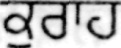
ਕੁਰਾਹ
